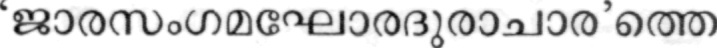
'ജാരസംഗമഘോരദുരാചാര'ത്തെ
